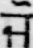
ਜੋ
